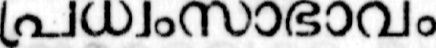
പ്രധ്വംസാഭാവം
